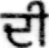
ਦੀ
